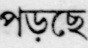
পড়ছে
